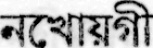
নখোয়গী
